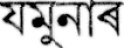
যমুনাৰ
